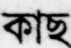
কাছ
